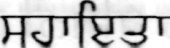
ਸਹਾਇਤਾ
